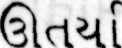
ઊતર્યા
